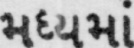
મધ્યમાં
